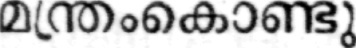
മന്ത്രംകൊണ്ടു
